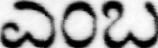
ಎಂಬ
